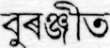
বুৰঞ্জীত
